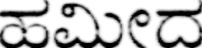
ಹಮೀದ
